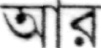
আর
